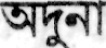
অদুনা
